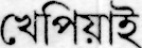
খেপিয়াই
